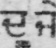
ਦੂਜੇ
